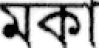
মকা
